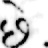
છે.
